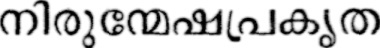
നിരുന്മേഷപ്രകൃത
